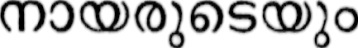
നായരുടെയും
